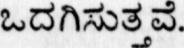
ಒದಗಿಸುತ್ತವೆ.
